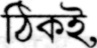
ঠিকই,
